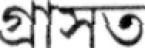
গ্ৰাসত
